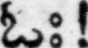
ಓಃ!
